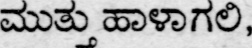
ಮುತ್ತುಹಾಳಾಗಲಿ,
